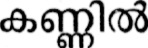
കണ്ണില്‍
